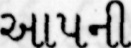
આપની
